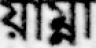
য়াম্না
